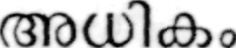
അധികം
